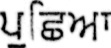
ਪੁਛਿਆ
